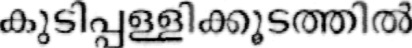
കുടിപ്പള്ളിക്കൂടത്തില്‍
